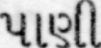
પાણી
